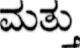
ಮತ್ತು
